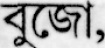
বুজো,
